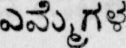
ಎಮ್ಮೆಗಳ
